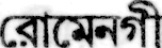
রোমেনগী
